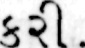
કરી.
